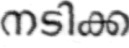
നടിക്ക
